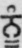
ਨੂੰ
